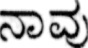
ನಾವು
